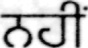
ਨਹੀਂ
